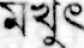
মখুৎ
